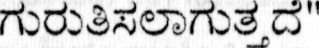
ಗುರುತಿಸಲಾಗುತ್ತದೆ”
